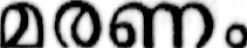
മരണം
